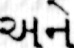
અને
